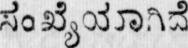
ಸಂಖ್ಯೆಯಾಗಿದೆ
